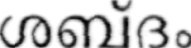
ശബ്ദം
